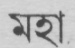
মহা
